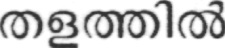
തളത്തില്‍
